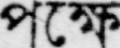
পক্ষে
